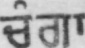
ਚੰਗਾ
